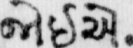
જોઈએ.
